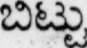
ಬಿಟ್ಟು
